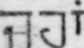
ਜਹਾਂ
